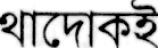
থাদোকই
